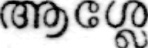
ആശ്ലേ
